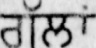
ਗੱਲਾਂ
